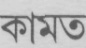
কামত
